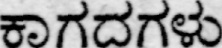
ಕಾಗದಗಳು
